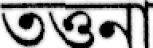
তত্তনা
